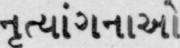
નૃત્યાંગનાઓ
